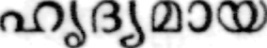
ഹൃദ്യമായ
